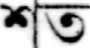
শত
